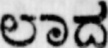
ಲಾದ
